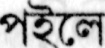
পইলে
